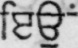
ਇਉਂ
